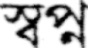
স্বপ্ন
